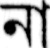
না
